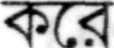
করে
